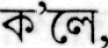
ক'লে,
